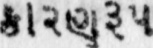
કારણરૂપ
